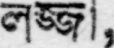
লজ্জা,
